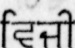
ਵਿਜੀ
